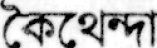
কৈথেন্দা
